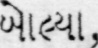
બોલ્યા,
